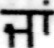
ਜਾਂ
